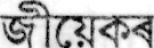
জীয়েকৰ
